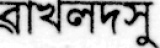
ৱাখলদসু
